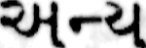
અન્ય
